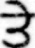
ਤੇ
